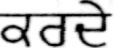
ਕਰਦੇ
